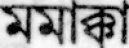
মমাক্কা
